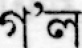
গ'ল
